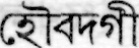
হৌবদগী
